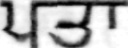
ਪਤਾ
